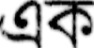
এক
